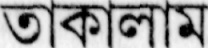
তাকালাম
